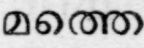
മത്തെ
